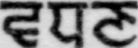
ਵਧਣ
